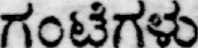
ಗಂಟೆಗಳು
